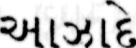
આઝાદે
